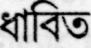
ধাবিত
